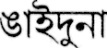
ঙাইদুনা
